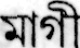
মাগী
